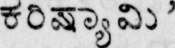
ಕರಿಷ್ಯಾಮಿ’
